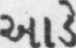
આડે
